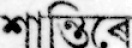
শান্তিৰে
